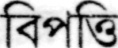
বিপত্তি
